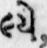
લ્યે,
